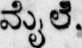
ಮೈಲೆ.
